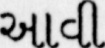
આવી
